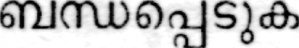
ബന്ധപ്പെടുക
